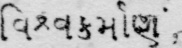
વિશ્વકર્માણં,કોટી
